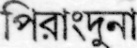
পিরাংদুনা
